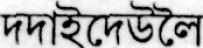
দদাইদেউলৈ
